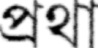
প্রথা
